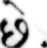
છે.
